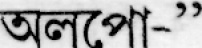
অলপো-"
